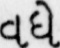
વધે
